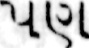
પણ
